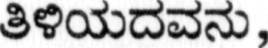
ತಿಳಿಯದವನು,
